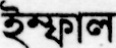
ইম্ফাল
